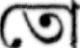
তো
